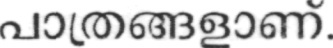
പാത്രങ്ങളാണ്.
